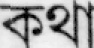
কথা
